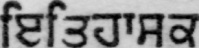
ਇਤਿਹਾਸਕ
